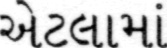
એટલામાં
